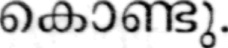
കൊണ്ടു.
